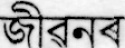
জীৱনৰ
